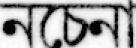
নচেনা
